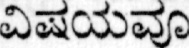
ವಿಷಯವೂ
